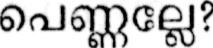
പെണ്ണല്ലേ?
